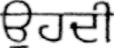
ਉਹਦੀ
